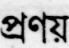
প্রণয়
